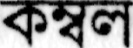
কম্বল
